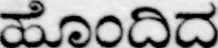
ಹೊಂದಿದ
